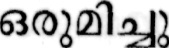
ഒരുമിച്ചു
